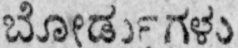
ಬೋರ್ಡುಗಳು
